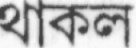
থাকল
